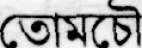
তোমচৌ
